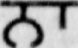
ਨਾ
